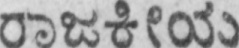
ರಾಜಕೀಯ
